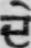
ਦੇ
